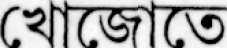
খোজোতে
